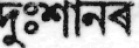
দুঃশানৰ
